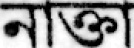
নাক্তা
